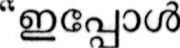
“ഇപ്പോള്‍
